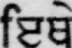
ਇਥੇ
